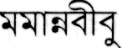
মমান্নবীবু
